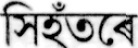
সিহঁতৰে
